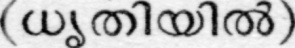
(ധൃതിയില്‍)
